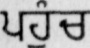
ਪਹੁੰਚ
